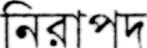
নিরাপদ
